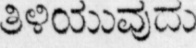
ತಿಳಿಯುವುದು
